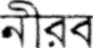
নীরব
